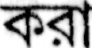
করা
